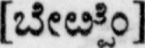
[ಬೇೞ್ಪೆಂ]
